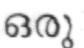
ഒരു
